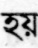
হয়
